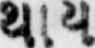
થાય
